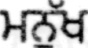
ਮਨੁੱਖ
